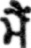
ਮੈਂ
